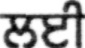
ਲਈ
